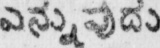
ಎನ್ನುವುದು
